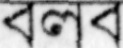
বলব
